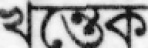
খন্তেক
